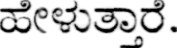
ಹೇಳುತ್ತಾರೆ.
